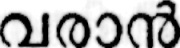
വരാന്‍
